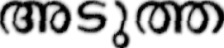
അടുത്ത
